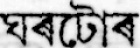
ঘৰটোৰ
